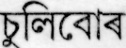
চুলিবোৰ
